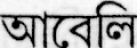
আবেলি
